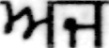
ਅਜ
